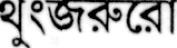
থুংজরুরো
